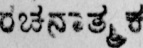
ರಚನಾತ್ಮಕ
